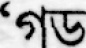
'গড
